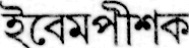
ইবেমপীশক
